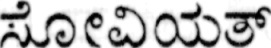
ಸೋವಿಯತ್
